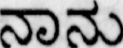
ನಾನು
